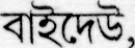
বাইদেউ,
